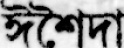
ঈশৈদা
